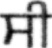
ਸੀ
